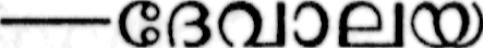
-ദേവാലയ
